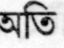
অতি
